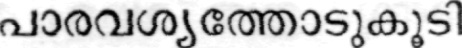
പാരവശ്യത്തോടുകൂടി
